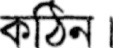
কঠিন।
